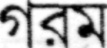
গরম
